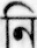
নি
